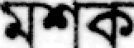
মশক
